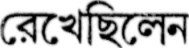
রেখেছিলেন
